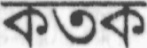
কতক
